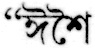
“ঈশৈ
